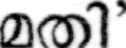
മതി’
